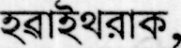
হৱাইথরাক,
